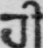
ਹੀ
